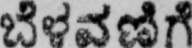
ಬೆಳವಣಿಗೆ
